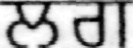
ਲਗ
